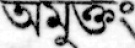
অমুক্তং
